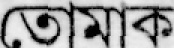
তোমাক
